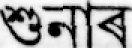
শুনাৰ
